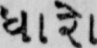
ધારો
